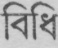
বিধি
